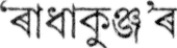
'ৰাধাকুঞ্জ'ৰ
